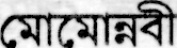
মোমোন্নবী
